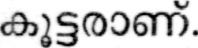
കൂട്ടരാണ്.
